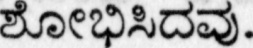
ಶೋಭಿಸಿದವು.
